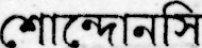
শেন্দোনসি
